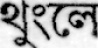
থুংলে
